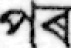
পৰ
